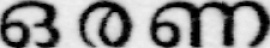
ഒരണ
